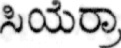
ಸಿಯೆರ್ರಾ
